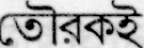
তৌরকই
